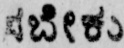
ಸಬೇಕು
